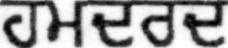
ਹਮਦਰਦ
